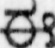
ಈ
